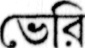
ভেরি
